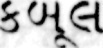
કબૂલ
